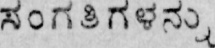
ಸಂಗತಿಗಳನ್ನು
